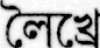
লৈখ্রে
